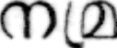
നമ്ര
